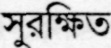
সুরক্ষিত
